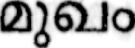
മുഖം
